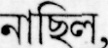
নাছিল,
